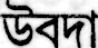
উবদা
